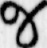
જ
